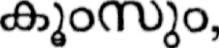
കൂംസും,
